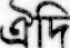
ঐদি
